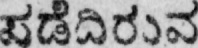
ಪಡೆದಿರುವ
